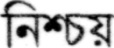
নিশ্চয়
